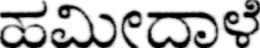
ಹಮೀದಾಳೆ
